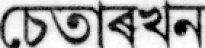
চেতাৰখন
